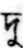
দু
